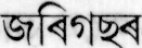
জৰিগছৰ
